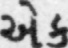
એક
